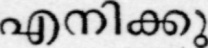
എനിക്കു
